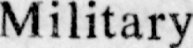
Military
